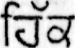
ਹਿੱਕ
